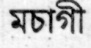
মচাগী
